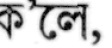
ক'লে,
